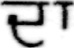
ਦਾ
